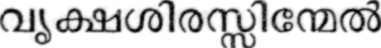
വൃക്ഷശിരസ്സിന്മേല്‍
